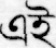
এই
